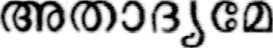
അതാദ്യമേ
